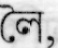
লৈ,
